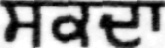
ਸਕਦਾ
